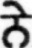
ਨੇ
